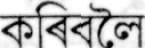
কৰিবলৈ
